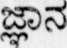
ಜ್ಞಾನ
